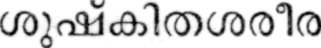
ശുഷ്കിതശരീര
